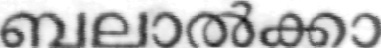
ബലാല്‍ക്കാ
